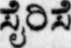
ಸೈರಿಸೆ
